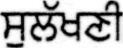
ਸੁਲੱਖਣੀ
